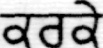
ਕਰਕੇ
